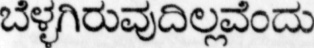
ಬೆಳ್ಳಗಿರುವುದಿಲ್ಲವೆಂದು
